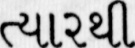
"ત્યારથી"
